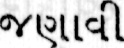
જણાવી
